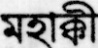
মহক্কী
